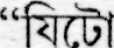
"যিটো
